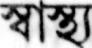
স্বাস্থ্য
